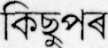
কিছুপৰ
